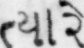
ત્યારે
